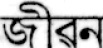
জীৱন
